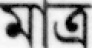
মাত্র
